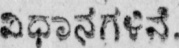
ವಿಧಾನಗಳಿವೆ.
